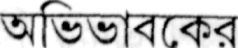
অভিভাবকের
